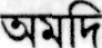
অমদি
